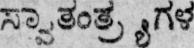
ಸ್ವಾತಂತ್ರ್ಯಗಳ
